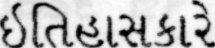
ઇતિહાસકારે
